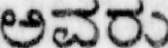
ಅವರು
